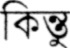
কিন্তু
